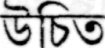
উচিত
